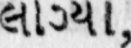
લાગ્યા,
